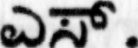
ಎಸ್.
